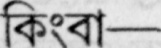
কিংবা-
